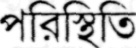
পরিস্থিতি
